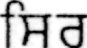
ਸਿਰ
